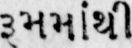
રૂમમાંથી
